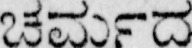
ಚರ್ಮದ
